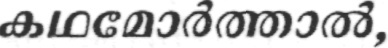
കഥമോര്‍ത്താല്‍,
